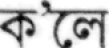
ক'লে
